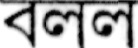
বলল
